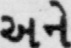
અને
